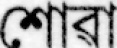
শোৱা
